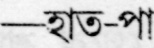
–হাত-পা
